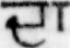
ਦਾ
